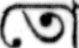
তো
